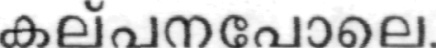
കല്പനപോലെ.
